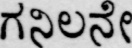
ಗನಿಲನೇ
